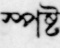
স্পষ্ট
